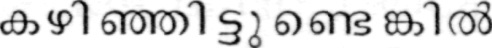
കഴിഞ്ഞിട്ടുണ്ടെങ്കില്‍
